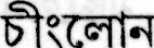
চীংলোন
